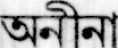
অনীনা
